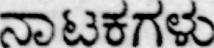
ನಾಟಕಗಳು
